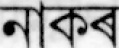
নাকৰ
